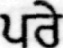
ਪਰੇ
